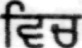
ਵਿਚ
